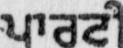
ਪਾਰਟੀ
